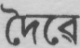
দৈৱে
